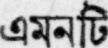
এমনটি
